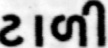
ટાળી
